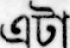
এটা
